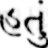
હતું
